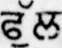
ਫੁੱਲ
